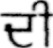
ਦੀ
